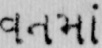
વનમાં
